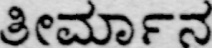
ತೀರ್ಮಾನ
